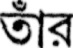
তাঁর
